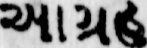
આગ્રહ
